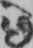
છે
